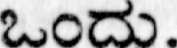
ಒಂದು.
